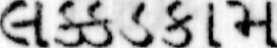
લક્કડકામ
